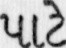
પાટે
